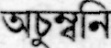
অচুম্বনি
